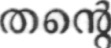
തന്റെ
